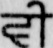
ਵੀ
